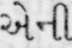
એની
